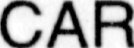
CAR
